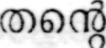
തന്റെ
